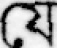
যে
